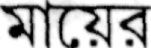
মায়ের
